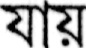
যায়
